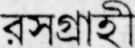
রসগ্রাহী
